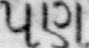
પણ
